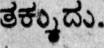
ತಕ್ಕುದು.
